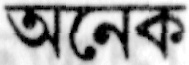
অনেক
